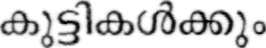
കുട്ടികള്‍ക്കും
